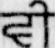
ਵੀ
